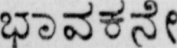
ಭಾವಕನೇ
